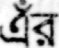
এঁর
